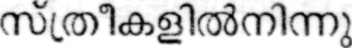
സ്ത്രീകളില്‍നിന്നു
